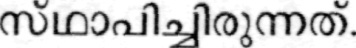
സ്ഥാപിച്ചിരുന്നത്.
